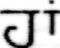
ਹਾਂ
